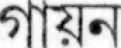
গায়ন
